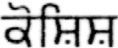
ਕੋਸ਼ਿਸ਼
